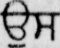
ਉਸ
